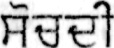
ਸੋਚਦੀ
